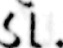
ડૉ.
